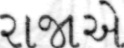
રાજાએ
